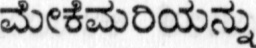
ಮೇಕೆಮರಿಯನ್ನು
